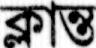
ক্লান্ত
